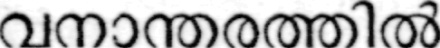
വനാന്തരത്തില്‍
